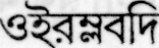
ওইরম্লবদি
